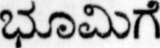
ಭೂಮಿಗೆ
